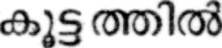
കൂട്ടത്തില്‍
